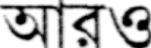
আরও
